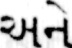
અને
